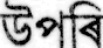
উপৰি
